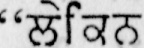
''ਲੇਕਿਨ
